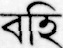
বহি
